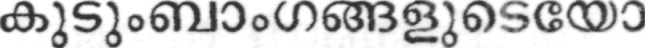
കുടുംബാംഗങ്ങളുടെയോ
